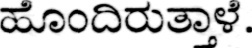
ಹೊಂದಿರುತ್ತಾಳೆ.
